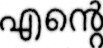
എന്റെ
